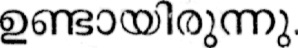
ഉണ്ടായിരുന്നു.
